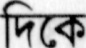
দিকে
